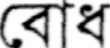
বোধ
